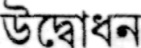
উদ্বোধন
